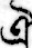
ঐ
